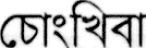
চোংখিবা
